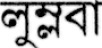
লুম্লবা
